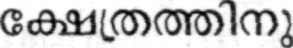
ക്ഷേത്രത്തിനു
